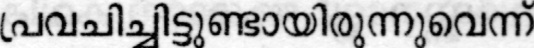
പ്രവചിച്ചിട്ടുണ്ടായിരുന്നുവെന്ന്
